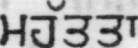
ਮਹੱਤਤਾ
